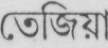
তেজিয়া
